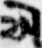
એ
